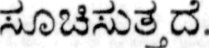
ಸೂಚಿಸುತ್ತದೆ.
